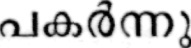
പകര്‍ന്നു
